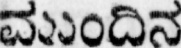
ಮುಂದಿನ
